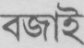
বজাই
